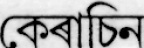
কেৰাচিন
